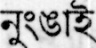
নুংঙাই
